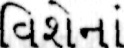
વિશેનાં
